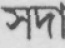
সদা
